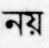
নয়
